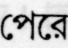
পেরে
